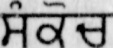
ਸੰਕੋਚ
